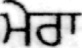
ਮੇਰਾ
